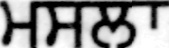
ਮਸਲਾ
